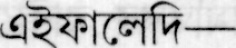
এইফালেদি-
